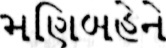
મણિબહેને
